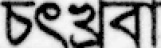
চৎখ্রবা
